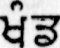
ਖੰਡ
